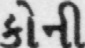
કોની
